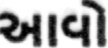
આવો
